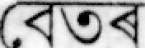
বেতৰ
